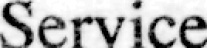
Service
